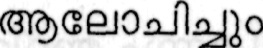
ആലോചിച്ചും
